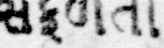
સફળતા
